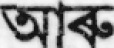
আৰু
